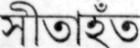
সীতাহঁত
